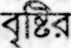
বৃষ্টির
